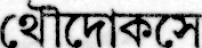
থৌদোকসে
